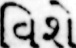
વિશે
